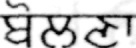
ਬੋਲਣਾ
